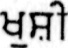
ਖੁਸ਼ੀ
